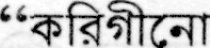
“করিগীনো
